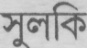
সুলকি
